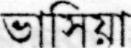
ভাসিয়া
